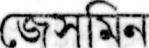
জেসমিন
